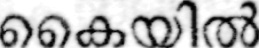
കൈയില്‍
